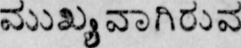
ಮುಖ್ಯವಾಗಿರುವ
